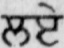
ਲਏ
